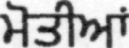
ਮੋਤੀਆਂ
